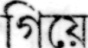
গিয়ে
